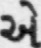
એ
